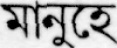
মানুহে
